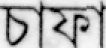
চাফা
